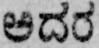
ಅದರ
